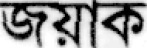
জয়াক
